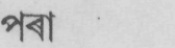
পৰা
